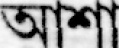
আশা
